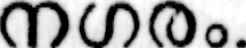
നഗരം.
